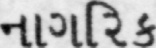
નાગરિક
